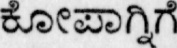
ಕೋಪಾಗ್ನಿಗೆ
